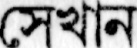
সেখান
